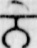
ਨੇ
